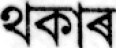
থকাৰ
